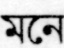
মনে
